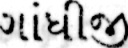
ગાંધીજી
